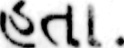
હતા.
